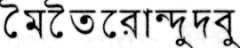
মৈতৈরোন্দুদাবু
